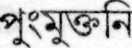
পুংমুক্তনি
